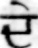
ਦੇ
